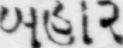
બહાર
